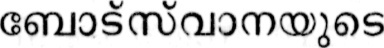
ബോട്സ്വാനയുടെ
